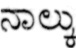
ನಾಲ್ಕು
